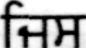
ਜਿਸ
